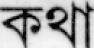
কথা
